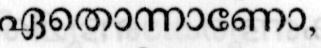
ഏതൊന്നാണോ,
